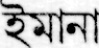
ইমানা
